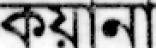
কয়ানা
